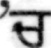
'ਚ
